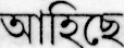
আহিছে
